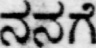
ನನಗೆ
